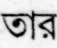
তার
